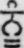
ਨੂੰ
